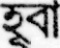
হূবা
